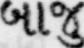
બાજુ
